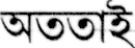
অততাই
